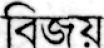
বিজয়
